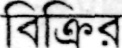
বিক্রির
